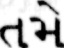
તમે
